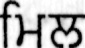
ਮਿਲ
